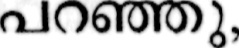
പറഞ്ഞു,
